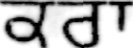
ਕਰਾ
